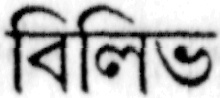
বিলিভ
